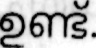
ഉണ്ട്.
